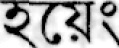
হয়েং
